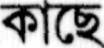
কাছে
